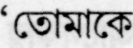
‘তোমাকে
